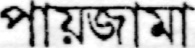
পায়জামা
